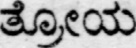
ತ್ರೋಯ
